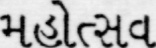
મહોત્સવ
